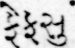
ફેફસું
